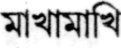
মাখামাখি
